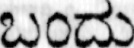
ಬಂದು
